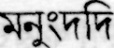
মনুংদদি
